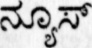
ನ್ಯೂಸ್
